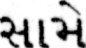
સામે
